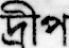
দ্রীপ
